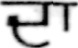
ਦਾ
